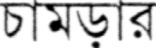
চামড়ার
